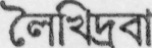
লৈখিদ্রবা
